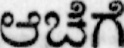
ಆಚೆಗೆ
